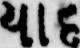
યાદ
